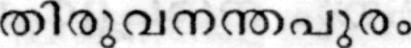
തിരുവനന്തപുരം
